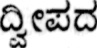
ದ್ವೀಪದ
